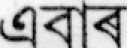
এবাৰ
